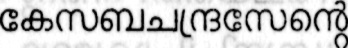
കേസബചന്ദ്രസേന്റെ
